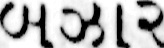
બઝાર
